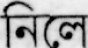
নিলে
